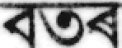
বতৰ
